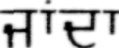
ਜਾਂਦਾ
